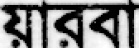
য়ারবা
